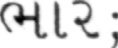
ભાર;
